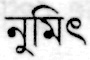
নুমিৎ
